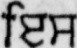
ਇਸ
